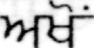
ਅਖੋਂ
